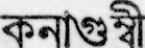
কনাগুম্বী
